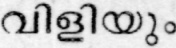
വിളിയും
